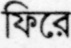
ফিরে
